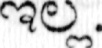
ಇಲ್ಲ.
